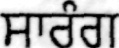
ਸਾਰੰਗ
